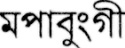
মপাবুংগী
